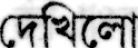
দেখিলো
